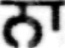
ਨਾ
